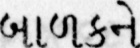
બાળકને
